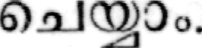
ചെയ്യാം.
